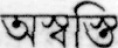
অস্বস্তি
